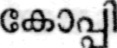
കോപ്പി
